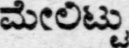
ಮೇಲಿಟ್ಟು
